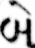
બે
